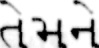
તેમને
